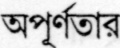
অপূর্ণতার
